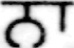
ਨਾ
